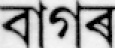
বাগৰ
